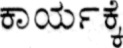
ಕಾರ್ಯಕ್ಕೆ
